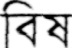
বিষ
